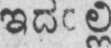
ಇದರಲ್ಲಿ
